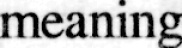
meaning
